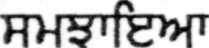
ਸਮਝਾਇਆ
